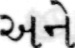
અને
